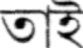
তাই
